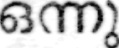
ഒന്നു
